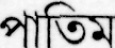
পাতিম
